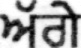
ਅੱਗੇ
